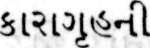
કારાગૃહની
